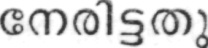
നേരിട്ടതു
